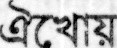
ঐখোয়
